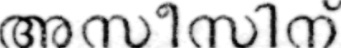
അസീസിന്
